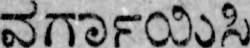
ವರ್ಗಾಯಿಸಿ
